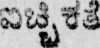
ಐಚ್ಛಿಕತೆ
